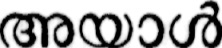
അയാള്‍
